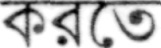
করতে
